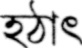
হঠাৎ
